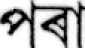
পৰা
